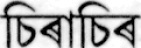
চিৰাচিৰ
